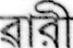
ৱারী
